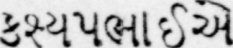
કશ્યપભાઈએ
